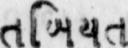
તબિયત
